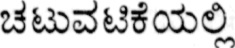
ಚಟುವಟಿಕೆಯಲ್ಲಿ
